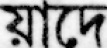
য়াদে
